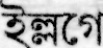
ইল্লগে
